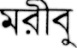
মরীবু
